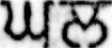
ਘਲ
